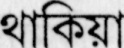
থাকিয়া
